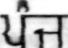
ਪੰਜ
